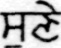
ਸੁਣੇ
